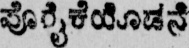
ಪೊರೈಕೆಯೊಡನೆ
